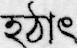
হঠাৎ
